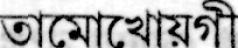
তামোখোয়গী
